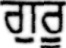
ਗੁਰੂ
